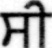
ਸੀ
